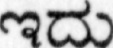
ಇದು
